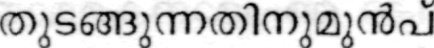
തുടങ്ങുന്നതിനുമുന്‍പ്
